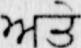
ਅਤੇ
